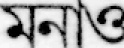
মনাও
